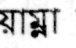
য়াম্না
